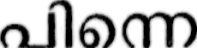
പിന്നെ
